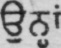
ਉਨ੍ਹਾਂ
